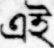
এই
